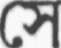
সে
